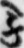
કે
